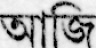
আজি
